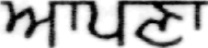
ਆਪਣਾ
